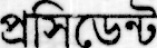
প্রসিডেন্ট
